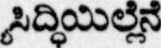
ಸಿದ್ಧಿಯಿಲ್ಲೆನೆ
